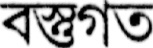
বস্তুগত
